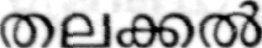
തലക്കല്‍
